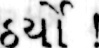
ઠર્યો
